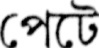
পেটে
